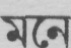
মনে
